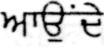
ਆਉਂਦੇ
